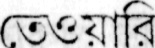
তেওয়ারি
